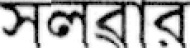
সলৱার
